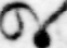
જ
